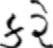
કરે
